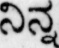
ನಿನ್ನ
